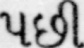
પછી
